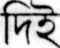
দিই
